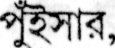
পুঁইসার,
